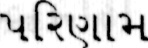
પરિણામ
